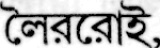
লৈররোই,
